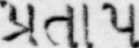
પ્રતાપ
